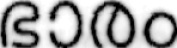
ഭാരം
